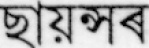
ছায়ন্সৰ
